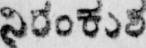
ನಿರಂಕುಶ
